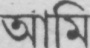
আমি
